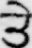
ਤੇ
